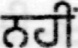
ਨਹੀਂ
